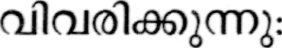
വിവരിക്കുന്നു:
